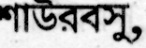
শাউরবসু,
